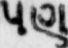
પણ
